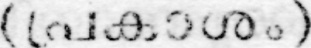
(പ്രകാശം)
